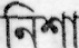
নিশা
